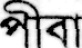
পীবা
